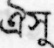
ঐসু
